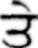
ਤੇ
